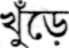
খুঁড়ে
